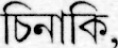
চিনাকি,
